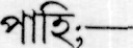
পাহি;-
